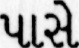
પાસે
